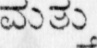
ಮತ್ತು
